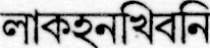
লাকহনখিবনি
